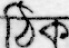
ঠিক
